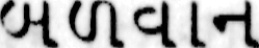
બળવાન
